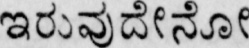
ಇರುವುದೇನೋ
